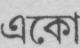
একো
